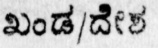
ಖಂಡ/ದೇಶ
